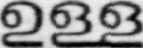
ഉള്ള
